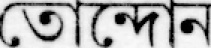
তোন্দোন
